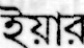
ইয়ার
